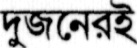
দুজনেরই
